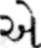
એ
